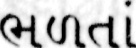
ભળતાં
